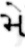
મે
